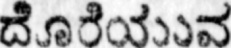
ದೊರೆಯುವ
